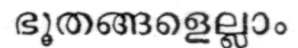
ഭൂതങ്ങളെല്ലാം
